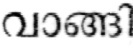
വാങ്ങി
